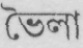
ভৈলা
